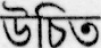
উচিত
